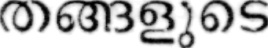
തങ്ങളുടെ
